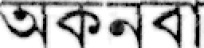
অকনবা
